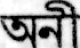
অনী
